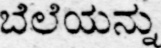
ಬೆಲೆಯನ್ನು
